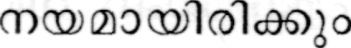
നയമായിരിക്കും
